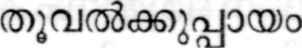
തൂവല്‍ക്കുപ്പായം
